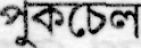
পুকচেল
